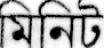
মিনিট
